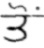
ਤੋਂ
